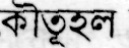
কৌতূহল
